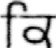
ਕਿ
